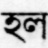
হল
